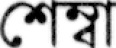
শেম্বা
